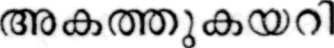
അകത്തുകയറി
